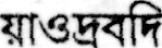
য়াওদ্রবদি
